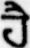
ਹੈ
